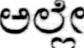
ಅಲ್ಲೇ
